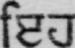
ਇਹ
